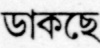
ডাকছে
